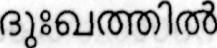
ദുഃഖത്തില്‍
